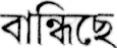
বান্ধিছে
